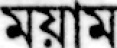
ময়াম
